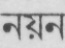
নয়ন
